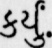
કર્યું.
